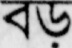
বড়
